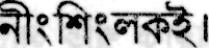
নীংশিংলকই।
